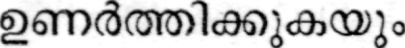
ഉണര്‍ത്തിക്കുകയും
